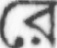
রে
